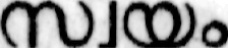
സ്വയം
